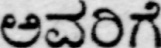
ಅವರಿಗೆ
